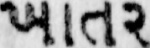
ખાતર
